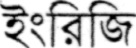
ইংরিজি
